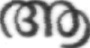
ആ
